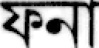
ফনা
